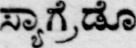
ಸ್ಯಾಗ್ರೆಡೊ
